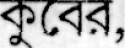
কুবের,
